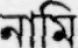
নামি
